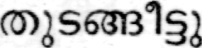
തുടങ്ങീട്ടു
